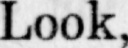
Look,
